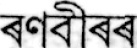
ৰণবীৰৰ
